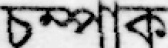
চম্পাক
